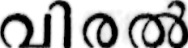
വിരല്‍
